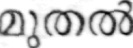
മുതല്‍
